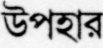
উপহার
